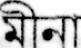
মীনা
